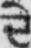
ਦੇ
